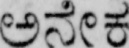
ಅನೇಕ
